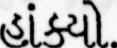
હાંક્યો.
